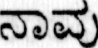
ನಾವು
